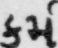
કર્મ
